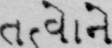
તત્વોને
